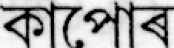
কাপোৰ
